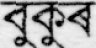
বুকুৰ
